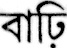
বাঢ়ি
